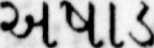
અષાડ
